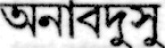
অনাবদুসু
